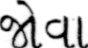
જોવા
